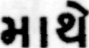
માથે
